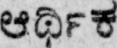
ಆರ್ಥಿಕ
